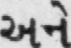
અને
